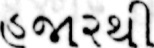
હજારથી
